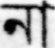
না
